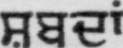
ਸ਼ਬਦਾਂ
